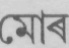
মোৰ
